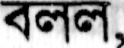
বলল,
